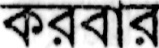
করবার
